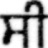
ਸੀ
